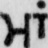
ਮਾਂ
